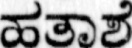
ಹತಾಶೆ
